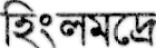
হিংলমদ্রে
